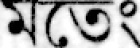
মতেং
